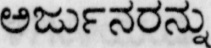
ಅರ್ಜುನರನ್ನು
